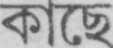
কাছে
